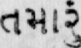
તમારું
